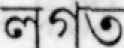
লগত
